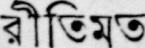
রীতিমত
